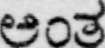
ಅಂತ
